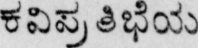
ಕವಿಪ್ರತಿಭೆಯ
